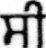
ਸੀ
